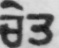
ਚੇਤ
